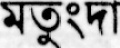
মতুংদা
